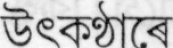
উৎকণ্ঠাৰে
